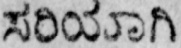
ಸರಿಯಾಗಿ
